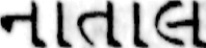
નાતાલ
